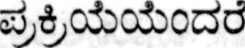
ಪ್ರಕ್ರಿಯೆಯೆಂದರೆ
